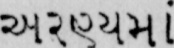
અરણ્યમાં
